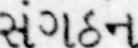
સંગઠન
